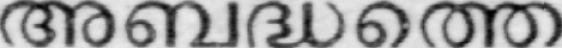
അബദ്ധത്തെ
